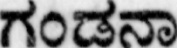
ಗಂಡನಾ
